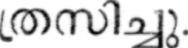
ത്രസിച്ചു.
